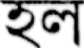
হল
